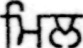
ਮਿਲ
